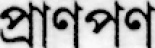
প্রাণপণ
